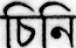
চিনি
